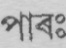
পাৰঃ
